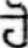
ਹੋ
